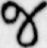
જ
